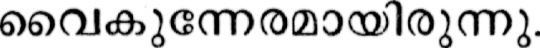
വൈകുന്നേരമായിരുന്നു.
